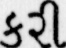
કરી
